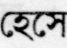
হেসে
